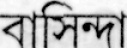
বাসিন্দা
